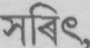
সৰিৎ,
